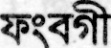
ফংবগী
